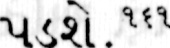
પડશે.૧૬૧
